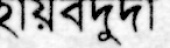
হায়বদুদা
